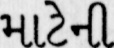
માટેની
